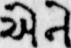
એને
